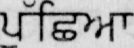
ਪੁੱਛਿਆ
